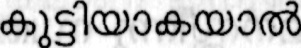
കുട്ടിയാകയാല്‍
